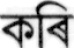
কৰি
